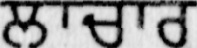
ਲਾਚਾਰ
